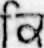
ਕਿ
